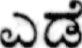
ಎಡೆ
